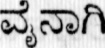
ವೈನಾಗಿ
